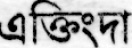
এক্টিংদা
